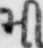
મી
